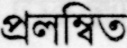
প্রলম্বিত
